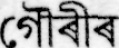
গৌৰীৰ
